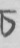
চ
